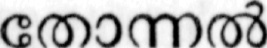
തോന്നല്‍
